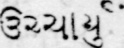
ઉચ્ચાર્યું
